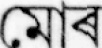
মোৰ
